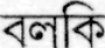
বলকি
